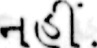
નહીં.
